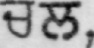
ਚਲ,
